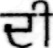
ਦੀ
